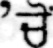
'ਚੋਂ
